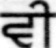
ਵੀ
